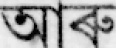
আৰু
